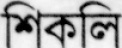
শিকলি
